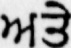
ਅਤੇ
